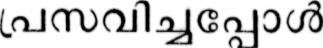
പ്രസവിച്ചപ്പോള്‍
